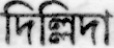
দিল্লিদা
